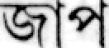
জাপ
